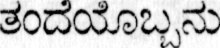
ತಂದೆಯೊಬ್ಬನು
